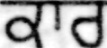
ਕਾਰ
